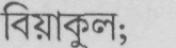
বিয়াকুল;
